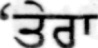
'ਤੇਰਾ
